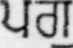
ਪਗੁ
